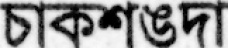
চাকশঙদা
